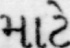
માટે
